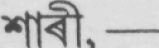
শাৰী,-
